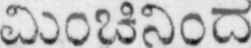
ಮಿಂಚಿನಿಂದ
